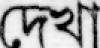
দেখা
